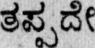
ತಪ್ಪದೇ
